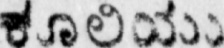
ಕೂಲಿಯು
